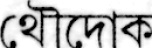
থৌদোক
